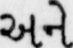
અને
